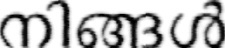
നിങ്ങള്‍
